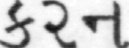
કરન
